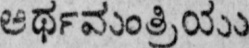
ಅರ್ಥಮಂತ್ರಿಯು
